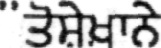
''ਤੋਸ਼ੇਖ਼ਾਨੇ
